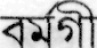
বর্মগী
